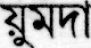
য়ুমদা
